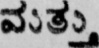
ಮತ್ತು
